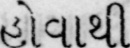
હોવાથી
